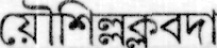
য়ৌশিল্লক্লবদা
